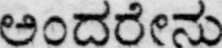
ಅಂದರೇನು
